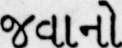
જવાનો
